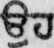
ਉਹ
